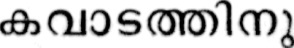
കവാടത്തിനു
